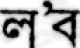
ল'ব
